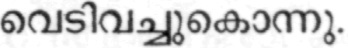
വെടിവച്ചുകൊന്നു.
